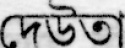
দেউতা
